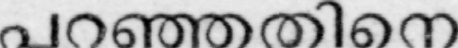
പറഞ്ഞതിനെ
